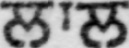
ਲਾਲ
